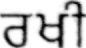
ਰਖੀ
